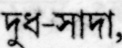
দুধ-সাদা,
